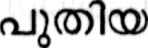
പുതിയ
